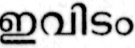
ഇവിടം
